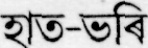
হাত-ভৰি
